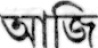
আজি
